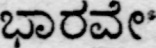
ಭಾರವೇ
